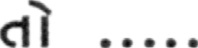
તો....
